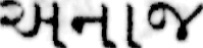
અનાજ
